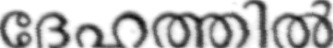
ദേഹത്തില്‍
